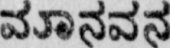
ಮಾನವನ
